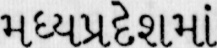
મધ્યપ્રદેશમાં
